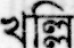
খল্লি
